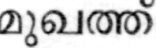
മുഖത്ത്
